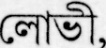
লোভী,
